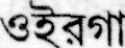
ওইরগা
